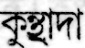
কুন্থ্রাদা
